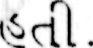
હતી.
